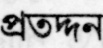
প্রতদ্দন
